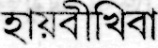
হায়বীখিবা
